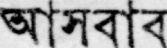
আসবাব
